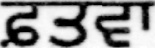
ਫ਼ਤਵਾ
